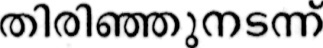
തിരിഞ്ഞുനടന്ന്
